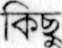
কিছু
